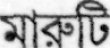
মারুটি
